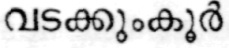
വടക്കുംകൂര്‍
